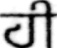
ਹੀ
